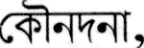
কৌনদনা,
